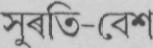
সুৰতি-বেশ
